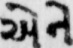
એને
